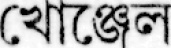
খোঞ্জেল
